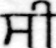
ਸੀ
